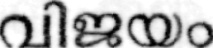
വിജയം
